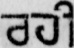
ਰਹੀ
